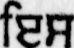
ਇਸ
